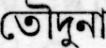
তৌদুনা
